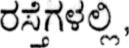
ರಸ್ತೆಗಳಲ್ಲಿ,
